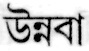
উন্নবা
